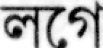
লগে
